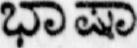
ಭಾಷಾ
